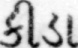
કીડા
